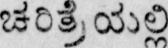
ಚರಿತ್ರೆಯಲ್ಲಿ
